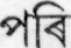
পৰি
